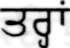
ਤਰ੍ਹਾਂ
